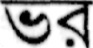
ভর
